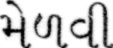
મેળવી
